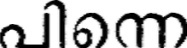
പിന്നെ
